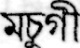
মচুগী
